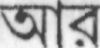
আর
